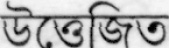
উত্তেজিত
